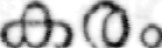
കരം
